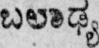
ಬಲಾಢ್ಯ
